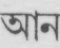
আন
